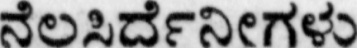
ನೆಲಸಿರ್ದೆನೀಗಳು
